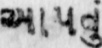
આપવું
